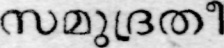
സമുദ്രതീ
